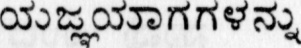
ಯಜ್ಞಯಾಗಗಳನ್ನು
